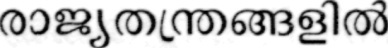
രാജ്യതന്ത്രങ്ങളില്‍
